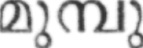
മുമ്പു
